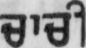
ਚਾਚੀ
